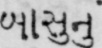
બાસુનું
